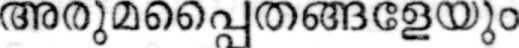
അരുമപ്പൈതങ്ങളേയും
